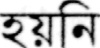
হয়নি
